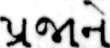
પ્રજાને
